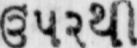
ઉપરથી
